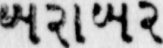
બરાબર
